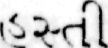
હસ્તી
